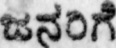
ಜನರಿಗೆ
